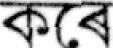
কৰে
